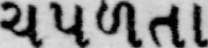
ચપળતા
